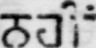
ਨਹੀਂ
